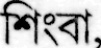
শিংবা,
